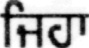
ਜਿਹਾ
